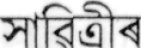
সাৱিত্রীৰ
